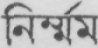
নিৰ্ম্মম
